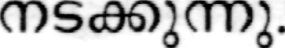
നടക്കുന്നു.
